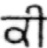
ਕੀ
